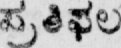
ಪ್ರತಿಫಲ
